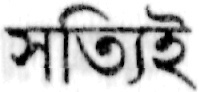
সত্যিই
